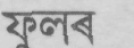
ফুলৰ
